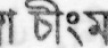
চীংম
